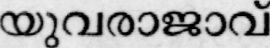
യുവരാജാവ്
